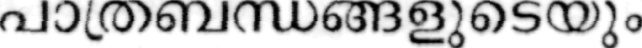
പാത്രബന്ധങ്ങളുടെയും
